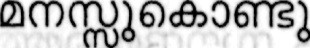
മനസ്സുകൊണ്ടു
